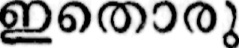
ഇതൊരു
